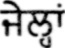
ਜੇਲ੍ਹਾਂ
